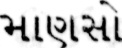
માણસો
